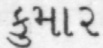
કુમાર
